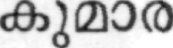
കുമാര
